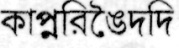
কাপ্নরিঙৈদদি
